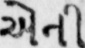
એની
